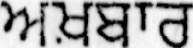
ਅਖ਼ਬਾਰ
